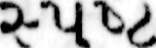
સ્પષ્ટ
